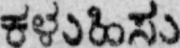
ಕಳುಹಿಸು
